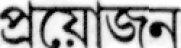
প্রয়োজন
